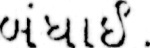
બંધાઈ.
